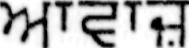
ਆਵਾਜ਼
